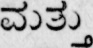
ಮತ್ತು
